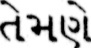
તેમણે
